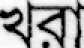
খরা
